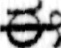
ಈ
